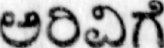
ಅರಿವಿಗೆ
